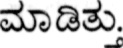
ಮಾಡಿತ್ತು.
